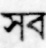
সব
